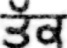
ਤੱਕ
